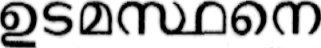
ഉടമസ്ഥനെ
